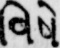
વિષે
